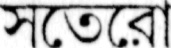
সতেরো
